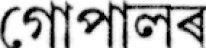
গোপালৰ
